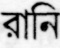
রানি
